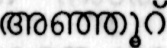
അഞ്ഞൂറ്
